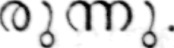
രുന്നു.
